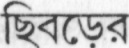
ছিবড়ের
